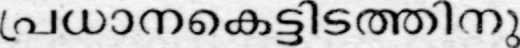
പ്രധാനകെട്ടിടത്തിനു
